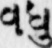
વધુ
